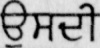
ਉਸਦੀ
